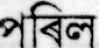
পৰিল
